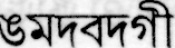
ঙমদবদগী
